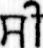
ਸੀ
